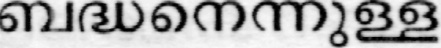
ബദ്ധനെന്നുള്ള
